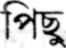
পিছু
